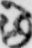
છે
